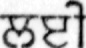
ਲਈ
